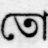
তো
